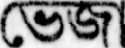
ভেজা
